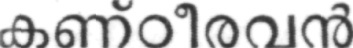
കണ്ഠീരവന്‍
